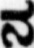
ನ
